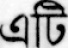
এটি
